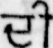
ਦੀ
